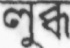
লুব্ধ
